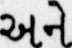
અને
